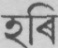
হৰি
